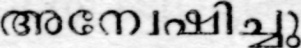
അന്വേഷിച്ചു
